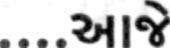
.......આજે
